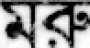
মরু
